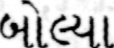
બોલ્યા
